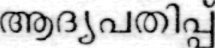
ആദ്യപതിപ്പ്
